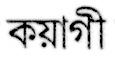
কয়াগী
